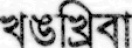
খঙখ্রিবা
